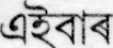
এইবাৰ
